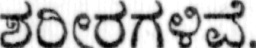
ಶರೀರಗಳಿವೆ.
